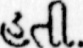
હતી.
